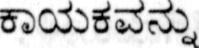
ಕಾಯಕವನ್ನು
